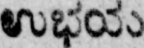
ಉಭಯ
